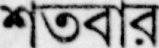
শতবার
